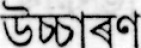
উচ্চাৰণ
